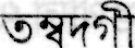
তম্বদগী
